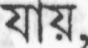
যায়,
